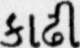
કાઢી
